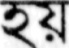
হয়
